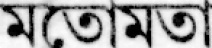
মতোমতা
